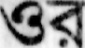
ওর
